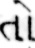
તો
